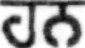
ਹਨ
